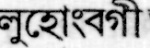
লুহোংবগী
